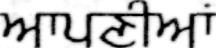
ਆਪਣੀਆਂ
